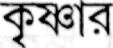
কৃষ্ণার
